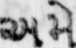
અમે
